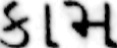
કામ
